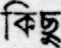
কিছু
